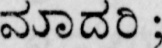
ಮಾದರಿ;
